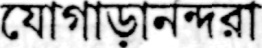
যোগাড়ানন্দরা
